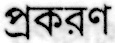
প্রকরণ
